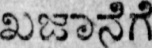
ಖಜಾನೆಗೆ
